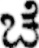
ಚೆ
